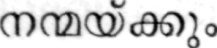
നന്മയ്ക്കും
